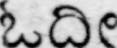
ಓದೀ
